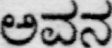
ಅವನ
